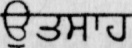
ਉਤਸਾਹ
